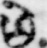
છે.
